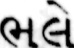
ભલે
